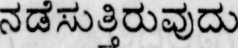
ನಡೆಸುತ್ತಿರುವುದು
